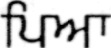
ਪਿਆ
